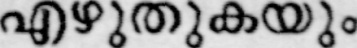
എഴുതുകയും
